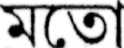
মতো
